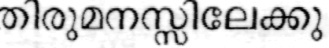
തിരുമനസ്സിലേക്കു
